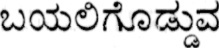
ಬಯಲಿಗೊಡ್ಡುವ
